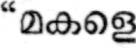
“മകളെ
